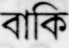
বাকি
